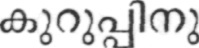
കുറുപ്പിനു
